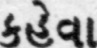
કહેવા
